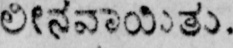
ಲೀನವಾಯಿತು.
